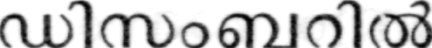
ഡിസംബറില്‍
